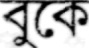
বুকে
